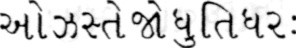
ઓઝસ્તેજોધુતિધરઃ
